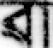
ৱা
